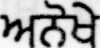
ਅਨੋਖੇ
